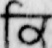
ਕਿ
